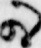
જે
